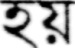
হয়
